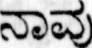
ನಾವು
